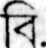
বি.
